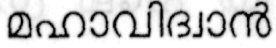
മഹാവിദ്വാന്‍
